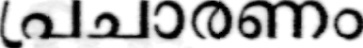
പ്രചാരണം
